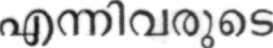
എന്നിവരുടെ
